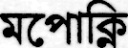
মপোক্নি
